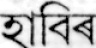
হাবিৰ
